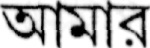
আমার
